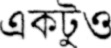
একটুও
